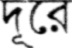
দূরে
